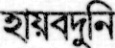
হায়বদুনি
